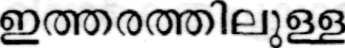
ഇത്തരത്തിലുള്ള
